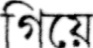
গিয়ে
